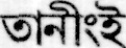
তানীংই
